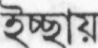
ইচ্ছায়
